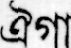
ঐগা
